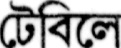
টেবিলে
